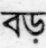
বড়
